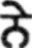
ਨੇ
